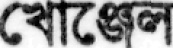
খোঞ্জেল
